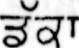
ਡੱਕਾ
